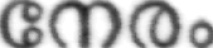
നേരം
